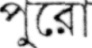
পুরো
